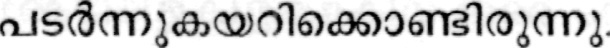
പടര്‍ന്നുകയറിക്കൊണ്ടിരുന്നു.
